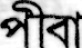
পীবা
